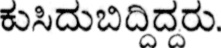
ಕುಸಿದುಬಿದ್ದಿದ್ದರು.
